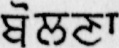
ਬੋਲਣਾ
